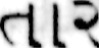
તાર
